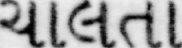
ચાલતા
